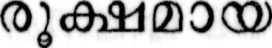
രൂക്ഷമായ
